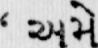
'અમે
